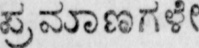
ಪ್ರಮಾಣಗಳೇ
